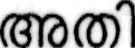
അതി
